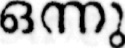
ഒന്നു
